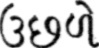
ઉછળે
